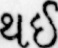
થઈ
